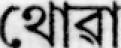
থোৱা
